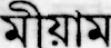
মীয়াম
